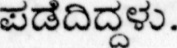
ಪಡೆದಿದ್ದಳು.
